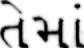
તેમાં
